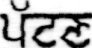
ਪੱਟਣ
